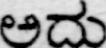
ಅದು
